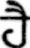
ਹੈ
